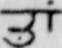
ਤਾਂ
